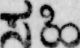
ಸಹಿ
